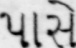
પાસે
